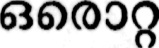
ഒരൊറ്റ
